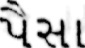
પૈસા
